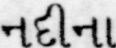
નદીના
